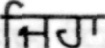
ਜਿਹਾ
